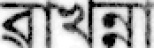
ৱাখন্না
